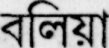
বলিয়া
